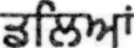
ਡਲਿਆਂ
